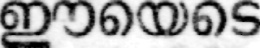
ഈയെടെ
